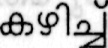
കഴിച്ച്
